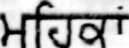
ਮਹਿਕਾਂ
